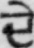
ਦੇ
